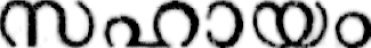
സഹായം
